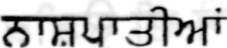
ਨਾਸ਼ਪਾਤੀਆਂ
